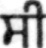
ਸੀ
